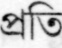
প্রতি
